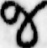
જ
